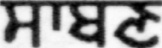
ਸਾਬਣ
